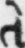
તે
